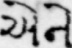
એને
